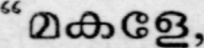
"മകളേ,
